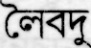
লৈবদু
